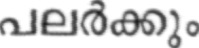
പലര്‍ക്കും
